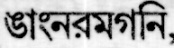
ঙাংনরমগনি,
